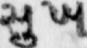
સુખ
